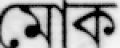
মোক
